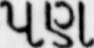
પણ
